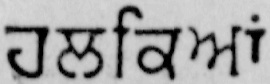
ਹਲਕਿਆਂ
